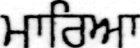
ਮਾਰਿਆ
